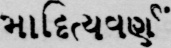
માદિત્યવર્ણ
